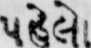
પહેલો
